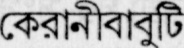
কেরানীবাবুটি
